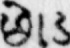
છોડ
